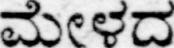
ಮೇಳದ
